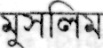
মুসলিম
